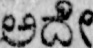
ಅದೇ
